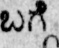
ಬಗ್ಗೆ
